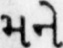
મને
